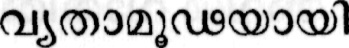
വ്യതാമൂഢയായി
